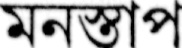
মনস্তাপ
